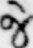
જે
